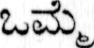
ಒಮ್ಮೆ
